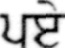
ਪਏ
